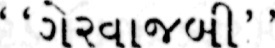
"ગેરવાજબી"
